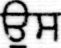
ਉਸ
